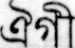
ঐগী
